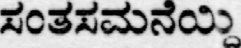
ಸ೦ತಸಮನೆಯ್ದಿ
